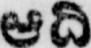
ಆದಿ
